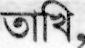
তাখি,
